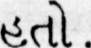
હતો.
